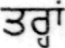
ਤਰ੍ਹਾਂ
